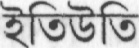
ইতিউতি
